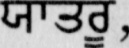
ਯਾਤਰੂ,
